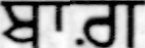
ਬਾਗ਼
